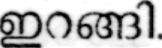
ഇറങ്ങി.
